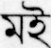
মই
